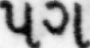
પગ
